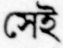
সেই
